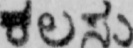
ಕಲಸು
